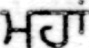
ਮਹਾਂ
